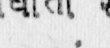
આધાતો
